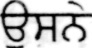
ਉਸਨੇ
